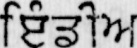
ਇੰਡੀਆ
